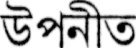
উপনীত
